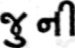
જુની
